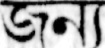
জন্য
